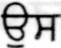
ਉਸ
